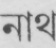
নাথ
